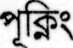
পূক্নিং
